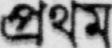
প্রথম
